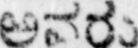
ಅವರು
